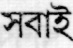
সবাই
